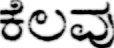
ಕೆಲವು
